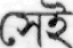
সেই
